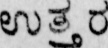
ಉತ್ತರ
